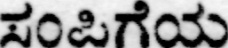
ಸಂಪಿಗೆಯ
